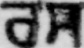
ਰਸ
